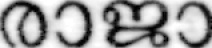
രാജാ
